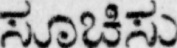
ಸೂಚಿಸು
